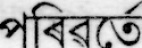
পৰিৱর্তে
